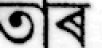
তাৰ
